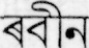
ৰবীন
